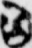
છે
